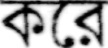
করে
